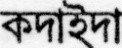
কদাইদা
